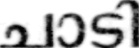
ചാടി
